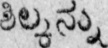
ಶಿಲ್ಕನ್ನು
